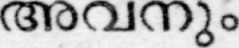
അവനും
